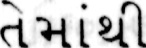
તેમાંથી
